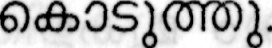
കൊടുത്തു.
